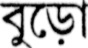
বুড়ো
